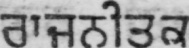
ਰਾਜਨੀਤਕ
